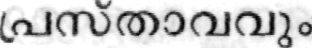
പ്രസ്താവവും
